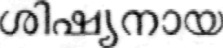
ശിഷ്യനായ
